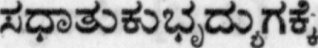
ಸಧಾತುಕುಭೃದ್ಯುಗಕ್ಕೆ
